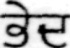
ਭੇਦ
